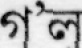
গ'ল
